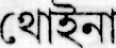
থোইনা
